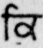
ਕਿ
